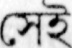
সেই
